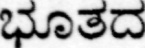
ಭೂತದ
